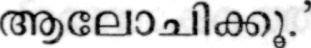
ആലോചിക്കൂ.'
